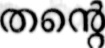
തന്റെ
